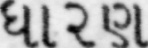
ધારણ
